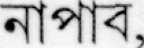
নাপাব,
